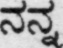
ನನ್ನ
